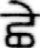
ਛੇ
